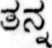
ತನ್ನ
